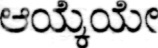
ಆಯ್ಕೆಯೇ
